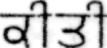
ਕੀਤੀ
